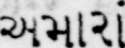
અમારા
